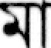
মা
